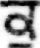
ਕੁ
